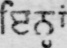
ਇਨ੍ਹਾਂ
